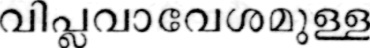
വിപ്ലവാവേശമുള്ള
